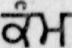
ਕੰਮ
